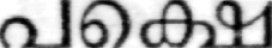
പക്ഷെ
